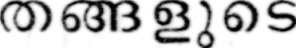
തങ്ങളുടെ
